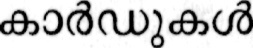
കാര്‍ഡുകള്‍
